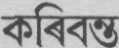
কৰিবন্ত
